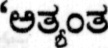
‘ಅತ್ಯಂತ
